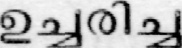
ഉച്ചരിച്ച
